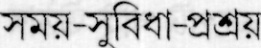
সময়-সুবিধা-প্রশ্ৰয়
